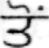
ਤੋਂ
